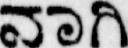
ವಾಗಿ
